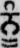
ਨੂੰ
